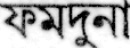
ফমদুনা
